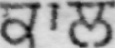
ਕਾਲ
